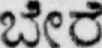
ಬೇರೆ
